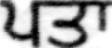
ਪਤਾ
